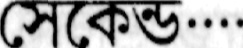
সেকেন্ড.....
